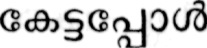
കേട്ടപ്പോള്‍
